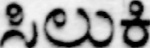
ಸಿಲುಕಿ
